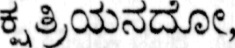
ಕ್ಷತ್ರಿಯನದೋ,
